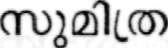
സുമിത്ര
